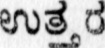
ಉತ್ತರ
